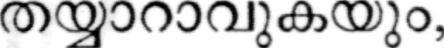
തയ്യാറാവുകയും,
